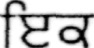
ਇਕ
